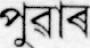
পুৱাৰ
